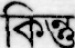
কিন্তু
